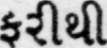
ફરીથી
